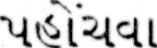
પહોંચવા
